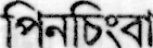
পিনচিংবা
